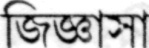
জিজ্ঞাসা
